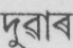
দুৱাৰ
